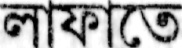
লাফাতে
